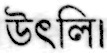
উৎলি।
